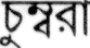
চুম্বরা
